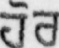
ਹੋਰ
